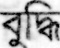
বুদ্ধি
